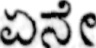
ಏನೇ
